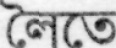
লৈতে
